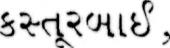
કસ્તૂરબાઈ,
